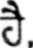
ਹੈ,
